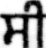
ਸੀ
